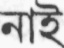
নাই
